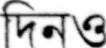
দিনও
